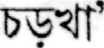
চড়খা’
